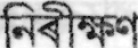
নিৰীক্ষণ
